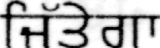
ਜਿੱਤੇਗਾ
